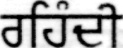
ਰਹਿੰਦੀ
